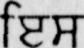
ਇਸ
